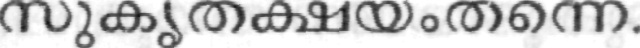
സുകൃതക്ഷയംതന്നെ.
